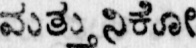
ಮತ್ತುನಿಕೋ
